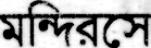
মন্দিরসে
